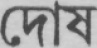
দোষ
